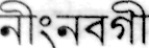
নীংনবগী
